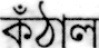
কঁঠাল
